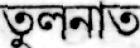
তুলনাত
